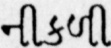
નીકળી
